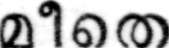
മീതെ
